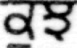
ਕੁਝ
